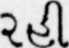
રહી
